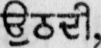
ਉਠਦੀ,
